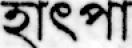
হাৎপা
